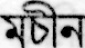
মচীন
